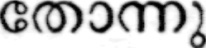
തോന്നു
